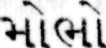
મોભો
